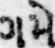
ગમે
